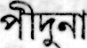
পীদুনা
